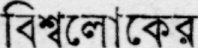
বিশ্বলোকের
